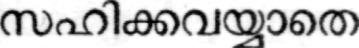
സഹിക്കവയ്യാതെ
